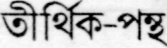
তীর্থিক-পন্থ
